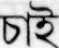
চাই
